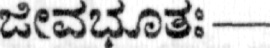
ಜೀವಭೂತಃ-
